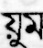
য়ুম
